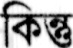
কিন্তু
